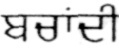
ਬਚਾਂਦੀ
